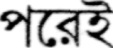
পরেই
